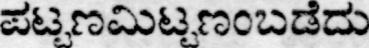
ಪಟ್ಟಣಮಿಟ್ಟಣಂಬಡೆದು
